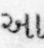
આ
